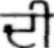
ਦੀ
